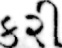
કરી
